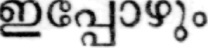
ഇപ്പോഴും
